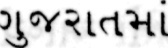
ગુજરાતમાં
